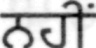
ਨਹੀਂ
